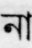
না
